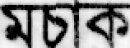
মচাক
